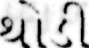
થોડી
